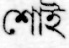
শোই
